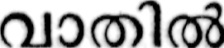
വാതില്‍
